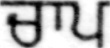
ਚਾਪ
